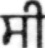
ਸੀ
